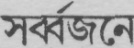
সৰ্ব্বজনে
